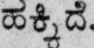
ಹಕ್ಕಿದೆ.
